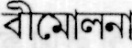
বীমোলনা
